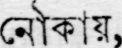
নৌকায়,
